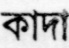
কাদা
